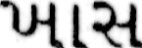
ખાસ
